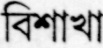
বিশাখা
